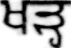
ਖੜ੍ਹ
